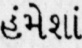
હંમેશાં
